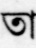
তা
